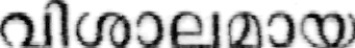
വിശാലമായ
